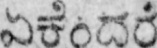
ಏಕೆಂದರೆ
